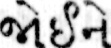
જોઈને
